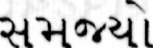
સમજ્યો
